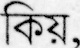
কিয়,
